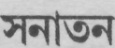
সনাতন
